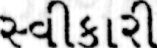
સ્વીકારી
